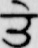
ਤੇ
